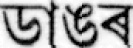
ডাঙৰ
